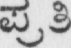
ಪ್ರತಿ
